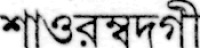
শাওরম্বদগী
